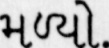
મળ્યો.
